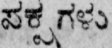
ಪಕ್ಷಗಳು
